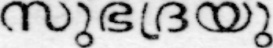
സുഭദ്രയു
